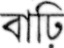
বাঢ়ি
